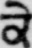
ਕੇ
